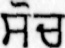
ਸੋਚ
